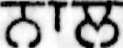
ਨਾਲ
